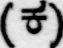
(ಕ)
